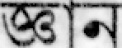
জ্ঞান
